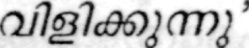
വിളിക്കുന്നു’
